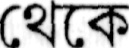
থেকে
